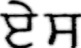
ਏਸ
